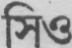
সিও
